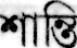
শান্তি
